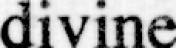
divine
